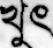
খুৎ
